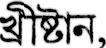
খ্ৰীষ্টান,
